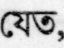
যেত,
